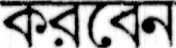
করবেন
